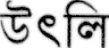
উৎলি
